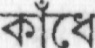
কাঁধে
